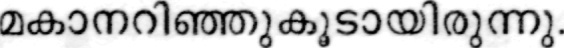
മകാനറിഞ്ഞുകൂടായിരുന്നു.
